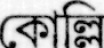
কোল্লি
